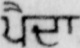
ਪੈਦਾ
